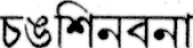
চঙশিনবনা
